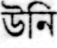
উনি
